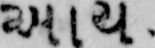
આય
